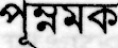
পূম্নমক
